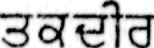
ਤਕਦੀਰ
